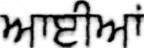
ਆਈਆਂ
